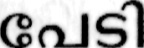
പേടി
